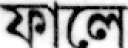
ফালে
